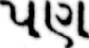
પણ
